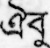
ঐবু
